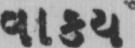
વાક્યં
